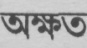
অক্ষত
